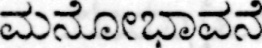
ಮನೋಭಾವನೆ
